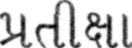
પ્રતીક્ષા
